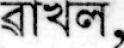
ৱাখল,
